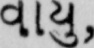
વાયુ,
